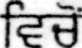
ਵਿਚੋਂ
